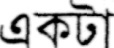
একটা
